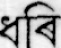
ধৰি
